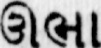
ઊભા
